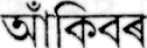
আঁকিবৰ
